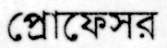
প্রোফেসর
